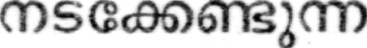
നടക്കേണ്ടുന്ന
